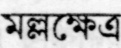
মল্লক্ষেত্র
